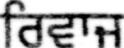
ਰਿਵਾਜ
